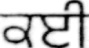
ਕਈ
